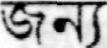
জন্য
